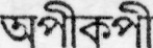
অপীকপী
